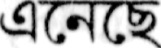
এনেছে
